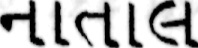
નાતાલ
